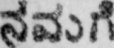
ನಮಗೆ
